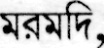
মরমদি,
